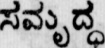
ಸಮೃದ್ಧ
